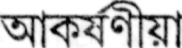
আকর্ষণীয়া
